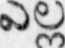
ಎಲ್ಲ
